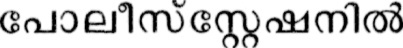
പോലീസ്സ്റ്റേഷനില്‍
